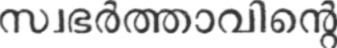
സ്വഭര്‍ത്താവിന്റെ
